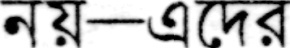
নয়–এদের
